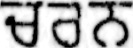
ਚਰਨ
